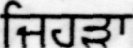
ਜਿਹੜਾ
